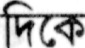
দিকে
